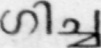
ഗിച്ച
